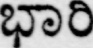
ಭಾರಿ
